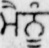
ਮੈਨੂੰ
